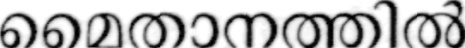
മൈതാനത്തില്‍
